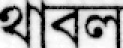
থাবল
